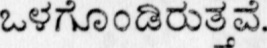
ಒಳಗೊಂಡಿರುತ್ತವೆ.
